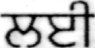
ਲਈ
